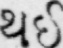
થઈ
